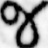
જ
